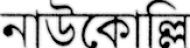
নাউকোল্লি
